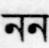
নন
